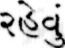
રહેવું
